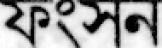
ফংসন
